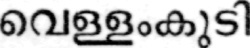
വെള്ളംകുടി
